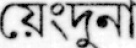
য়েংদুনা
